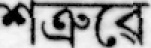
শত্রুৱে
